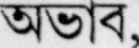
অভাব,
